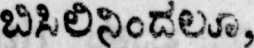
ಬಿಸಿಲಿನಿಂದಲೂ,
